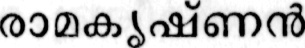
രാമകൃഷ്ണന്‍
